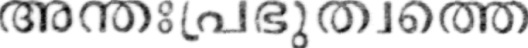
അന്തഃപ്രഭുത്വത്തെ
